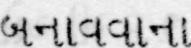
બનાવવાના
